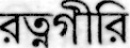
রত্নগীরি
